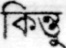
কিন্তু
